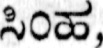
ಸಿಂಹ,
